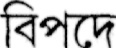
বিপদে
